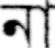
না
